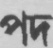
পদ
